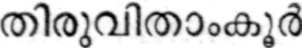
തിരുവിതാംകൂര്‍
